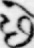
છે
